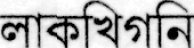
লাকখিগনি
